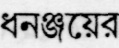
ধনঞ্জয়ের
